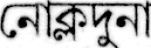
নোক্লদুনা
